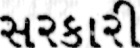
સરકારી
